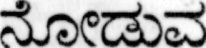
ನೋಡುವ
